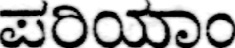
ಪರಿಯಾಂ
